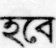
হবে
